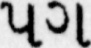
પગ
